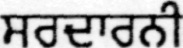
ਸਰਦਾਰਨੀ
